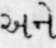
અને
